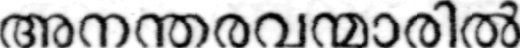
അനന്തരവന്മാരില്‍
